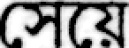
সেয়ে
